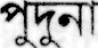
পুদুনা
